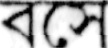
বসে
